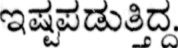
ಇಷ್ಟಪಡುತ್ತಿದ್ದ.
